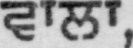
ਵਾਲਾ,
